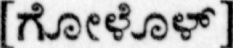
[ಗೋಳೊಳ್]
